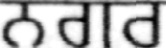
ਨਗਰ
